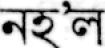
নহ'ল
